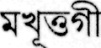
মখূত্তগী
